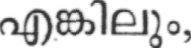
എങ്കിലും,
